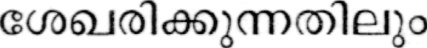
ശേഖരിക്കുന്നതിലും
